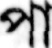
পা
